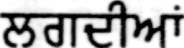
ਲਗਦੀਆਂ
